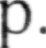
p.
